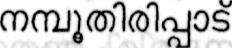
നമ്പൂതിരിപ്പാട്
